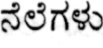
ನೆಲೆಗಳು
